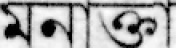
মনাক্তা
